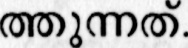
ത്തുന്നത്.
